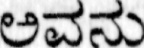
ಅವನು
